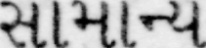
સામાન્ય
